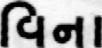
વિના
